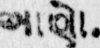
આણો.
